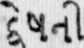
દ્વેષની
